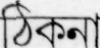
ঠিকনা
